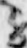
કે
